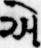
એ
